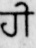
ਹੀ
